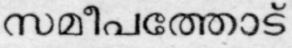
സമീപത്തോട്
